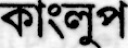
কাংলুপ
